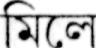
মিলে
